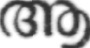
ആ
